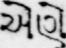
એણે
